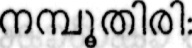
നമ്പൂതിരി:
